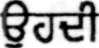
ਉਹਦੀ
